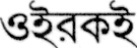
ওইরকই
